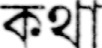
কথা
